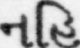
નહિ
